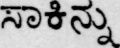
ಸಾಕಿನ್ನು
